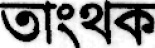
তাংথক
